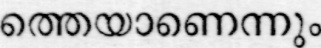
ത്തെയാണെന്നും
